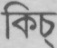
কিচ্
